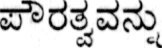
ಪೌರತ್ವವನ್ನು
